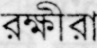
রক্ষীরা
